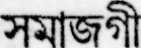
সমাজগী
